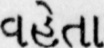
વહેતા
